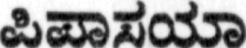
ಪಿಪಾಸಯಾ
